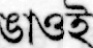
ঙাওই
